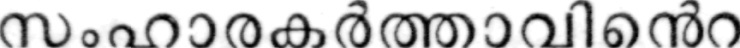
സംഹാരകര്‍ത്താവിന്റെ
